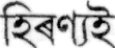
হিৰণ্যই
